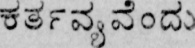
ಕರ್ತವ್ಯವೆಂದು
